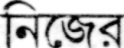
নিজের
